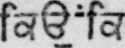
ਕਿਉਂਕਿ
